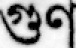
গুণ
